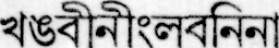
খঙবীনীংলবনিনা
